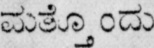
ಮತ್ತೊಂದು
